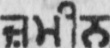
ਜ਼ਮੀਨ
